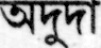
অদুদা
